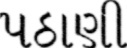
પઠાણી
